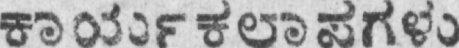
ಕಾರ್ಯಕಲಾಪಗಳು
